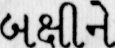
બક્ષીને
